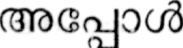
അപ്പോള്‍
